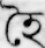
হৈ
